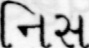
નિસ
